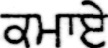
ਕਮਾਏ
